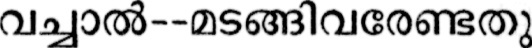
വച്ചാല്‍--മടങ്ങിവരേണ്ടതു
